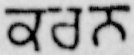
ਕਰਨ
